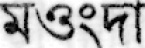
মওংদা
